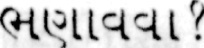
ભણાવવા?
